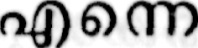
എന്നെ
